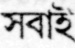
সবাই
